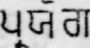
ਪ੍ਰਯੋਗ
